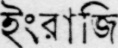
ইংরাজি
